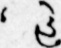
'હે
